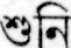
শুনি
